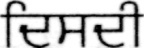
ਦਿਸਦੀ
